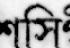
ঐনা
